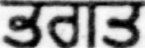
ਭਗਤ
